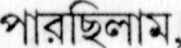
পারছিলাম,
